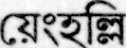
য়েংহল্লি
